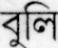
বুলি
